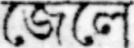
জেলে
